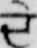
ਦੇ
